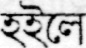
হইলে
